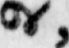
જ,
